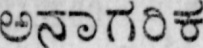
ಅನಾಗರಿಕ
